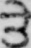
ਤੇ
